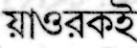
য়াওরকই
